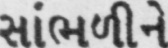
સાંભળીને
